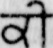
ਕੀ
